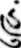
હું
